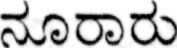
ನೂರಾರು
